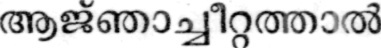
ആജ്ഞാച്ചീറ്റത്താല്‍
